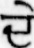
ਦੇ
